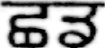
ਛਡ
